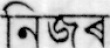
নিজৰ
